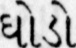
ઘોડો
